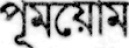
পূময়োম
